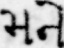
મને
